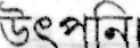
উৎপনি।
